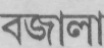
বজালা
